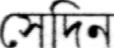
সেদিন
